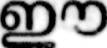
ഈ
